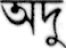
অদু
